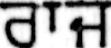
ਰਾਜ
